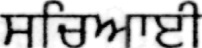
ਸਚਿਆਈ
